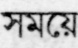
সময়ে
